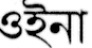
ওইনা
